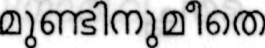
മുണ്ടിനുമീതെ
